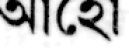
আহো
